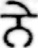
ਨੇ
